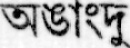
অঙাংদু
